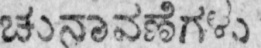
ಚುನಾವಣೆಗಳು
